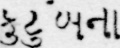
કુંટુબના
